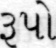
રૂપો
